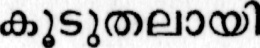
കൂടുതലായി
